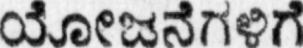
ಯೋಜನೆಗಳಿಗೆ
